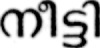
നീട്ടി
